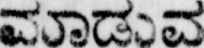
ಮಾಡುವ
